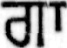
ਗਾ
